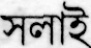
সলাই
